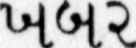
ખબર
